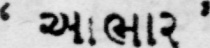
'આભાર'
